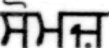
ਸੋਮਜ਼
